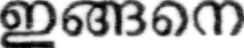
ഇങ്ങനെ
